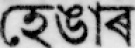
হেঙাৰ
